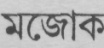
মজোক
